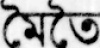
মৈতৈ
